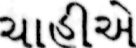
ચાહીએ
